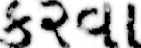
કરવા
